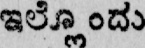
ಇಲ್ಲೊಂದು
